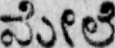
ಮೇಲೆ
